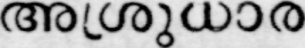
അശ്രുധാര
